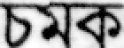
চমক
